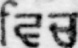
ਵਿਚ
